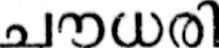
ചൌധരി
